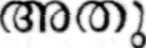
അതു
